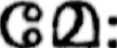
മേ:
